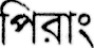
পিরাং
